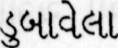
ડુબાવેલા
